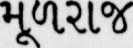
મૂળરાજ
